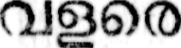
വളരെ
